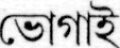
ভোগাই
